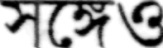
সঙ্গেও
